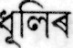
ধূলিৰ
